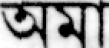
অমা
